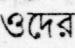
ওদের
